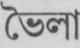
ভৈলা
